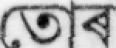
তোৰ
